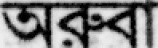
অরুবা
